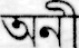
অনী
